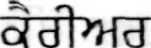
ਕੈਰੀਅਰ
